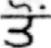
ਤੋਂ
